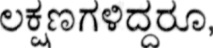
ಲಕ್ಷಣಗಳಿದ್ದರೂ,
